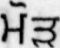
ਮੋੜ
